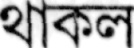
থাকল
